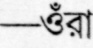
–ওঁরা
